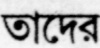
তাদের
